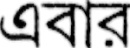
এবার
